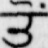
ਤੋਂ
